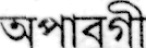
অপাবগী
